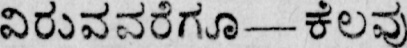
ವಿರುವವರೆಗೂ-ಕೆಲವು
